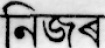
নিজৰ
